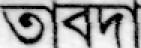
তাবদা
